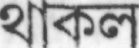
থাকল
